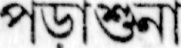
পড়াশুনা
